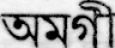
অমগী
